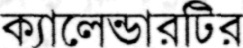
ক্যালেন্ডারটির
